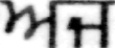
ਅਜ
